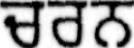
ਚਰਨ
